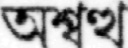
অশ্বত্থ
